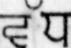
ਵੱਧ
